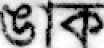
ঙাক
